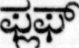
ಫ್ಲಫ್
